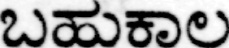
ಬಹುಕಾಲ
